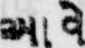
આવે
